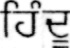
ਹਿੰਦੂ
